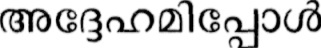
അദ്ദേഹമിപ്പോള്‍
